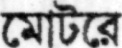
মোটরে
